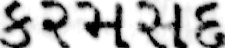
કરમસદ
